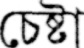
চেষ্টা
